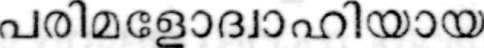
പരിമളോദ്വാഹിയായ
